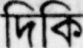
দিকি
